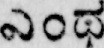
ಎಂಥ
